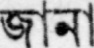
জানা
